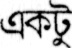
একটু
